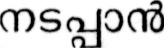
നടപ്പാന്‍
